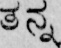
ತನ್ನ
